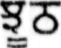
ਝੂਠ
